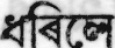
ধৰিলে
